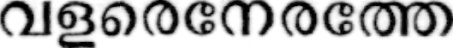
വളരെനേരത്തേ
